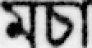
মচা
